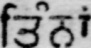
ਤਿੰਨਾਂ
